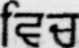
ਵਿਚ
